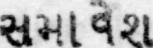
સમાવેશ
